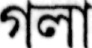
গলা
